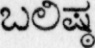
ಬಲಿಷ್ಠ
